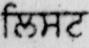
ਲਿਸਟ
